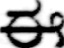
ಈ
